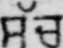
ਸੱਚ
